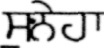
ਸੁਨੇਹਾ
